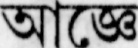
আজ্ঞে
